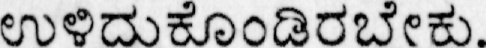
ಉಳಿದುಕೊಂಡಿರಬೇಕು.
